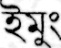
ইমুং
